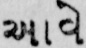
આવે
